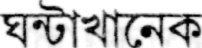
ঘন্টাখানেক
